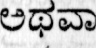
ಅಥವಾ
